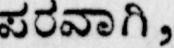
ಪರವಾಗಿ,
